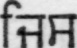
ਜਿਸ
